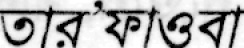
তার’ফাওবা
